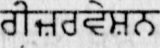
ਰੀਜ਼ਰਵੇਸ਼ਨ
